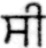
ਸੀ
